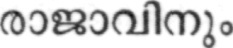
രാജാവിനും
